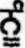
ਨੂੰ
